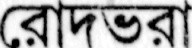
রোদভরা
